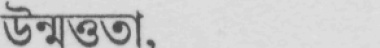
উন্মত্ততা,
